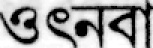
ওৎনবা
